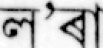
ল'ৰা
